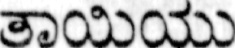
ತಾಯಿಯು
